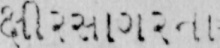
ક્ષીરસાગરના
